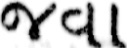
જવા
